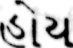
હોય
